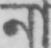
না
